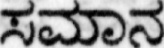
ಸಮಾನ
